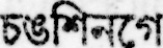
চঙশিনগে
